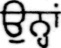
ਉਨ੍ਹਾਂ
